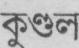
কুণ্ডল
